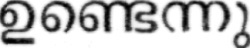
ഉണ്ടെന്നു
